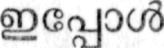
ഇപ്പോള്‍
